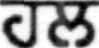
ਹਲ
